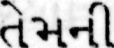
તેમની
